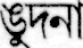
ঙুদনা
